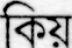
কিয়
